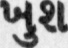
ખુશ
